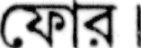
ফোর।
